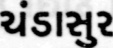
ચંડાસુર
